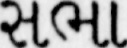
સભા
